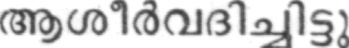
ആശീര്‍വദിച്ചിട്ടു
